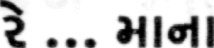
રે...નોરતા
